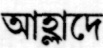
আহ্লাদে
